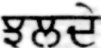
ਝਲਦੇ
